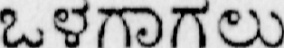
ಒಳಗಾಗಲು
